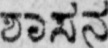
ಶಾಸನ
